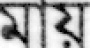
মায়
